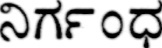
ನಿರ್ಗಂಧ
